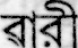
ৱারী
